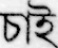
চাই
